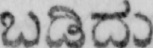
ಬಡಿದು
